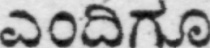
ಎಂದಿಗೂ
